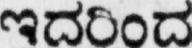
ಇದರಿಂದ
